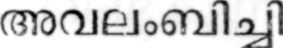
അവലംബിച്ചി
